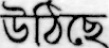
উঠিছে
